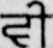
ਵੀ
